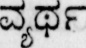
ವ್ಯರ್ಥ
